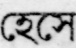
হেসে
